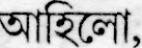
আহিলো,
